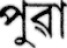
পুৱা
